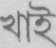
খাই
